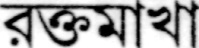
রক্তমাখা
